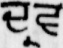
ਦ੍ਰਵ
